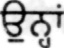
ਉਨ੍ਹਾਂ
